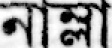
নাম্লা
